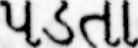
પડતા
